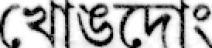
খোঙদোং
